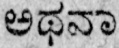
ಅಥವಾ
